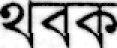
থবক
